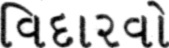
વિદારવો
